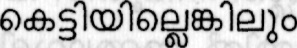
കെട്ടിയില്ലെങ്കിലും
